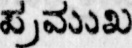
ಪ್ರಮುಖ
